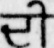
ਦੀ
